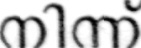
നിന്ന്
